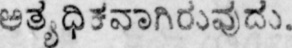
ಅತ್ಯಧಿಕವಾಗಿರುವುದು.
